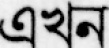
এখন
